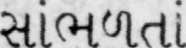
સાંભળતાં
